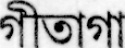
গীতাগা
